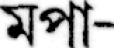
মপা-
